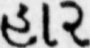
હાર
